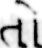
તો
